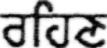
ਰਹਿਣ
